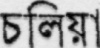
চলিয়া
